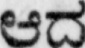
ಆದ
